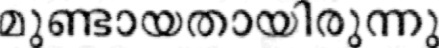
മുണ്ടായതായിരുന്നു
